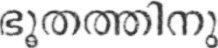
ഭൂതത്തിനു
